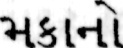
મકાનો
